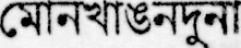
মোনখাঙনদুনা
